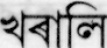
খৰালি
